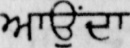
ਆਉਂਦਾ
